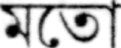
মতো
